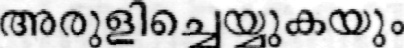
അരുളിച്ചെയ്യുകയും
